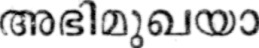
അഭിമുഖയാ
